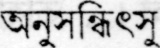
অনুসন্ধিৎসু
